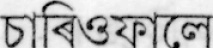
চাৰিওফালে
